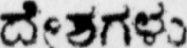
ದೇಶಗಳು
